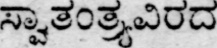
ಸ್ವಾತಂತ್ರ್ಯವಿರದ
